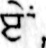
ਏਂ,
